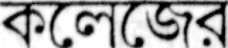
কলেজের
